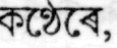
কণ্ঠেৰে,
